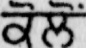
ਕੋਲੋਂ
